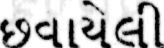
છવાયેલી
